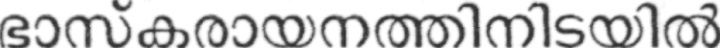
ഭാസ്കരായനത്തിനിടയില്‍
